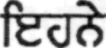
ਇਹਨੇ
